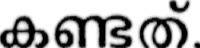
കണ്ടത്.
